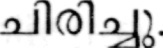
ചിരിച്ചു.
